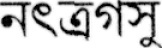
নৎত্রগসু
